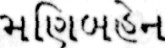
મણિબહેન
